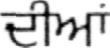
ਦੀਆਂ
